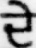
ਦੇ
